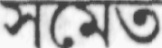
সমেত
